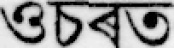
ওচৰত
